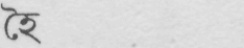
হৈ
